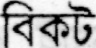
বিকট
